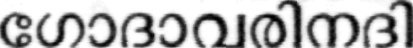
ഗോദാവരിനദി
